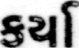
કર્યા
